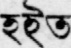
হইত
